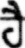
ਹੈ
